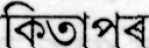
কিতাপৰ
